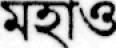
মহাও
